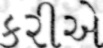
કરીએ
